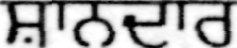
ਸ਼ਾਨਦਾਰ
